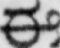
ಈ
